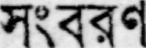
সংবরণ
